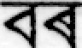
বৰ
